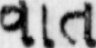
વાત
